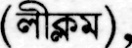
(লীক্লম),
